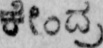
ಕೇಂದ್ರ
